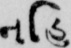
નહિ
